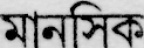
মানসিক
